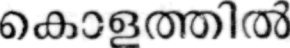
കൊളത്തില്‍
